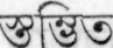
স্তম্ভিত
